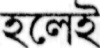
হলেই
